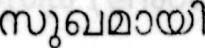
സുഖമായി
